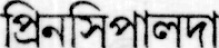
প্রিনসিপালদা
